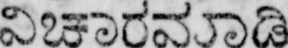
ವಿಚಾರಮಾಡಿ
